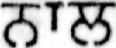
ਨਾਲ
